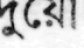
দুয়ো
